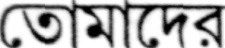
তোমাদের
